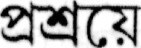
প্রশ্রয়ে
